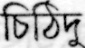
চিঠিদু
